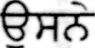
ਉਸਨੇ
